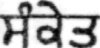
ਸੰਕੇਤ
